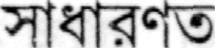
সাধারণত
